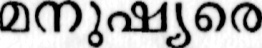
മനുഷ്യരെ
